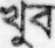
খুব
